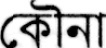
কৌনা
